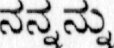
ನನ್ನನ್ನು
